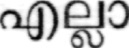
എല്ലാ
